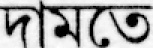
দামতে
